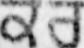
ਕਰ
